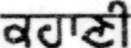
ਕਹਾਣੀ
